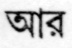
আর
